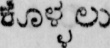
ಕೊಳ್ಳಲು
